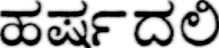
ಹರ್ಷದಲಿ
